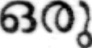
ഒരു
